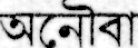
অনৌবা
